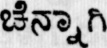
ಚೆನ್ನಾಗಿ
